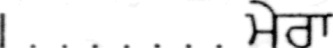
।..............ਮੇਰਾ
